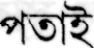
পতাই
